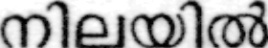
നിലയില്‍
